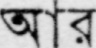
আর
